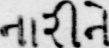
નારીને
